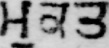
ਮੁਕਤ
